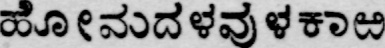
ಹೋಮುದಳವುಳಕಾಱ
